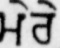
ਮੇਰੇ
